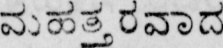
ಮಹತ್ತರವಾದ
